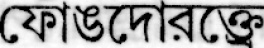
ফোঙদোরক্ত্রে
